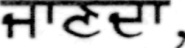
ਜਾਣਦਾ,
